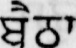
ਬੈਠਾ
